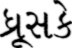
ધ્રૂસકે
